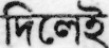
দিলেই
